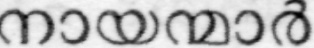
നായന്മാര്‍
